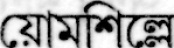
য়োমশিল্লে
